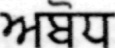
ਅਬੋਧ
